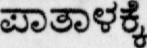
ಪಾತಾಳಕ್ಕೆ
